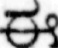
ಈ
